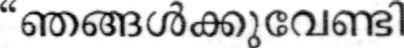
“ഞങ്ങള്‍ക്കുവേണ്ടി
